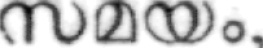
സമയം,
